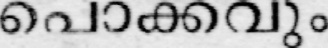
പൊക്കവും
